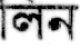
লিন
